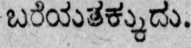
ಬರೆಯತಕ್ಕುದು.
